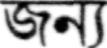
জন্য
